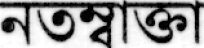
নতম্বাক্তা
